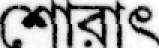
শোরাৎ
